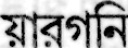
য়ারগনি
